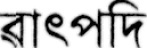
ৱাৎপদি
